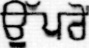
ਉੱਪਰੋਂ
